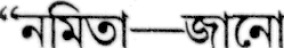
"নমিতা-জানো
